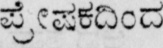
ಪ್ರೇಷಕದಿಂದ
